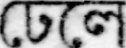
ঢেলে
